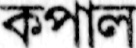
কপাল
